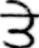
ਤੇ
